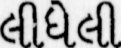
લીધેલી
